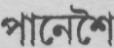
পানেশৈ
